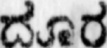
ದೂರ
